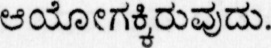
ಆಯೋಗಕ್ಕಿರುವುದು.
